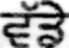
ਵੱਡੇ
